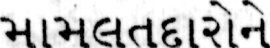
મામલતદારોને
